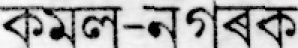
কমল-নগৰক
